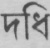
দধি
